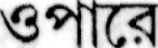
ওপারে
